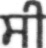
ਸੀ
